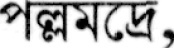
পল্লমদ্রে,
